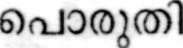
പൊരുതി
